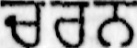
ਚਰਨ
